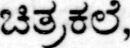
ಚಿತ್ರಕಲೆ,
